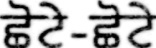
ਛੋਟੇ-ਛੋਟੇ
